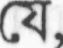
যে,
